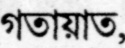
গতায়াত,
